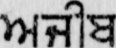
ਅਜੀਬ
